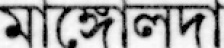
মাঙ্গোলদা
